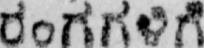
ರಂಗಗಳಿಗೆ
